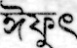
ঈফুৎ
